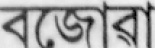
বজোৱা
